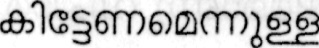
കിട്ടേണമെന്നുള്ള
